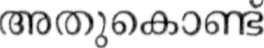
അതുകൊണ്ട്
